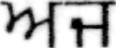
ਅਜ
